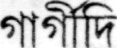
গার্গীদি
